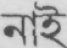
নাই
